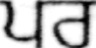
ਪਰ
